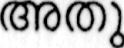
അതു
